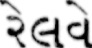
રેલવે
